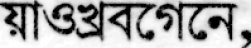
য়াওখ্রবগেনে,
